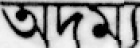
অদম্য
